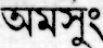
অমসুং
